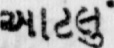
આટલું
